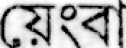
য়েংবা
